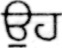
ਉਹ
